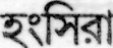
হংসিরা
